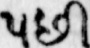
પછી
